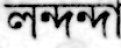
লন্দন্দা
